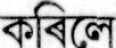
কৰিলে
